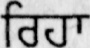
ਰਿਹਾ
